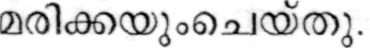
മരിക്കയുംചെയ്തു.
